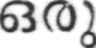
ഒരു
